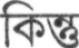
কিন্তু
